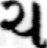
ચ
